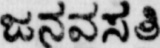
ಜನವಸತಿ
